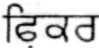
ਫ਼ਿਕਰ
